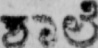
ಶಾಲೆ
